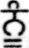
ਨੂੰ
